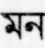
মন
